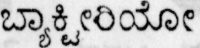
ಬ್ಯಾಕ್ಟೀರಿಯೋ
